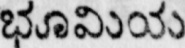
ಭೂಮಿಯ
